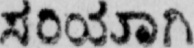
ಸರಿಯಾಗಿ
